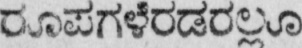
ರೂಪಗಳೆರಡರಲ್ಲೂ
